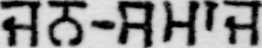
ਜਨ-ਸਮਾਜ
